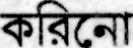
করিনো
